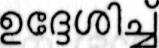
ഉദ്ദേശിച്ച്
